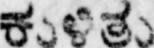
ಕುಳಿತು
